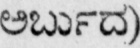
ಅರ್ಬುದ)
